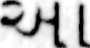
આ
